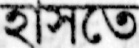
হাসতে
